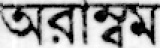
অরাম্বম
